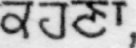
ਕਹਣਾ,
